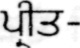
ਪ੍ਰੀਤ-
